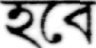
হবে
